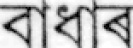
বাধাৰ
